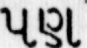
પણ
